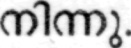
നിന്നു.
